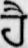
ਹੈ
